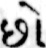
છો
